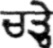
ਚੜ੍ਹੇ
